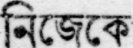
নিজেকে
